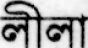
লীলা
